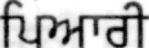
ਪਿਆਰੀ
